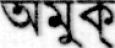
অমুক্
